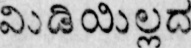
ಮಿಡಿಯಿಲ್ಲದ
